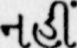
નહીં
